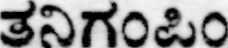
ತನಿಗಂಪಿಂ
